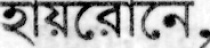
হায়রোনে,
